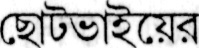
ছোটভাইয়ের
